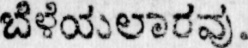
ಬೆಳೆಯಲಾರವು.
